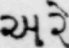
અરે
